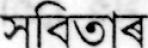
সবিতাৰ
